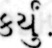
કર્યું.
